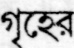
গৃহের
